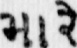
મારે
